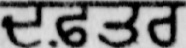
ਦਫ਼ਤਰ
